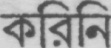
করিনি
